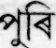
পুৰি
